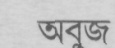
অবুজ
